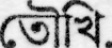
তৌখি.
